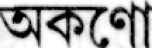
অকণো
